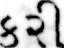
કરી
